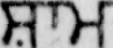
ਸ਼ਾਮ
